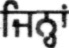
ਜਿਨ੍ਹਾਂ
